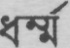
ধৰ্ম্ম
